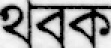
থবক
